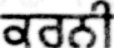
ਕਰਨੀ
